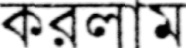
করলাম
